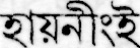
হায়নীংই
